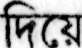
দিয়ে
